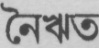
নৈঋত
